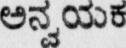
ಅನ್ವಯಕ
